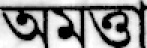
অমত্তা
